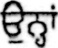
ਉਨ੍ਹਾਂ
